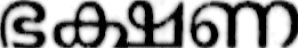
ഭക്ഷണ
